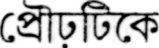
প্রৌঢ়টিকে
